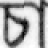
চা
